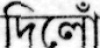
দিলোঁ
